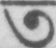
ত
